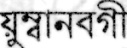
য়ুম্বানবগী
